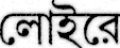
লোইরে
